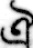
ঐ
